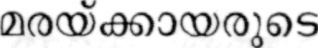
മരയ്ക്കായരുടെ
